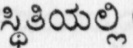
ಸ್ಥಿತಿಯಲ್ಲಿ
